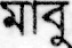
মাবু
